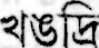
খঙদ্রি
